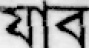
যাব
